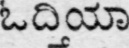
ಓದ್ತಿಯಾ
